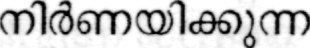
നിര്‍ണയിക്കുന്ന
